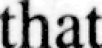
that
